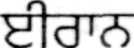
ਈਰਾਨ
